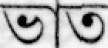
ভাত
